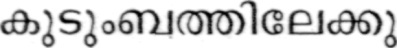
കുടുംബത്തിലേക്കു
